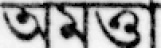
অমত্তা
